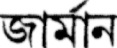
জার্মান
